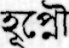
হূপ্নৌ
